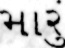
મારું
